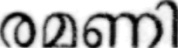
രമണി
